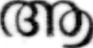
ആ
